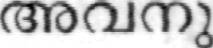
അവനു
